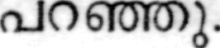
പറഞ്ഞു.
